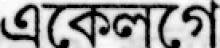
একেলগে
